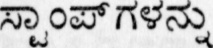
ಸ್ಟಾಂಪ್‌ಗಳನ್ನು
